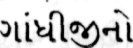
ગાંધીજીનો
